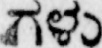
ಗಳು
